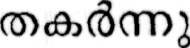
തകര്‍ന്നു
